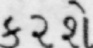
કરશે
